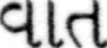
વાત
